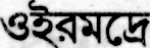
ওইরমদ্রে
